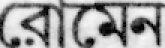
রোমেন
